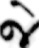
જે
